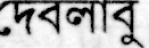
দেবলাবু
